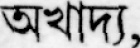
অখাদ্য,
